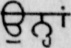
ਉਨ੍ਹਾਂ
